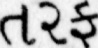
તરફ
